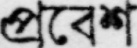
প্রবেশ
